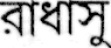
রাধাসু
